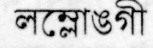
লম্লোঙগী
